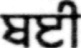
ਬਈ
